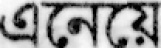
এনেয়ে
